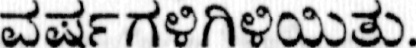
ವರ್ಷಗಳಿಗಿಳಿಯಿತು.
